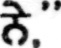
ਨੇ,''
